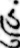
હું
